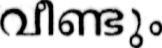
വീണ്ടും
